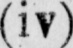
(iv)
